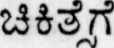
ಚಿಕಿತ್ಸೆಗೆ
